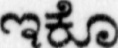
ಇಕೊ
